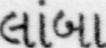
લાંબા
